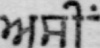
ਅਸੀਂ
